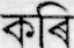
কৰি
